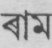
ৰাম
